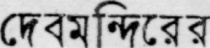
দেবমন্দিরের
